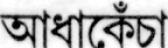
আধাকেঁচা
